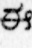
ಈ
